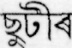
ছুটীৰ
